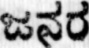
ಜನರ
